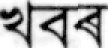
খবৰ
